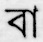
বা
